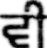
ਵੀ
